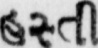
હસ્તી
